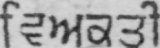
ਵਿਅਕਤੀ
